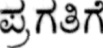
ಪ್ರಗತಿಗೆ
